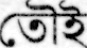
তৌই
